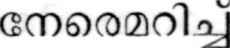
നേരെമറിച്ച്
